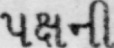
પક્ષની
